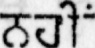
ਨਹੀਂ
